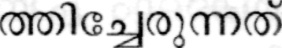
ത്തിച്ചേരുന്നത്
